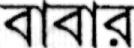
বাবার
